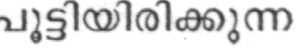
പൂട്ടിയിരിക്കുന്ന
